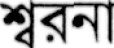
শ্বরনা
